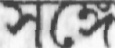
সঙ্গে
